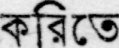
করিতে
